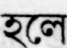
হলে
